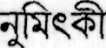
নুমিৎকী
